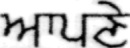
ਆਪਣੇ
